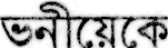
ভনীয়েকে
